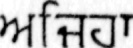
ਅਜਿਹਾ
